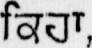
ਕਿਹਾ,
